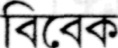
বিবেক
